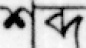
শব্দ
